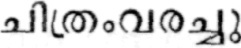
ചിത്രംവരച്ചു
